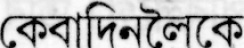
কেবাদিনলৈকে
